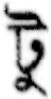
টু
